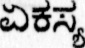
ಏಕಸ್ಯ
